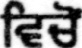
ਵਿਚੋਂ
